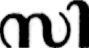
സി
